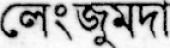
লেংজুমদা
